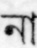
না
